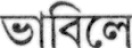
ভাবিলে
